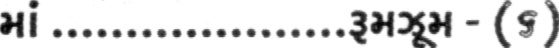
માં.....................રૂમઝૂમ-(૬)
